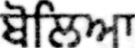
ਬੋਲਿਆ
